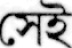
সেই
